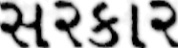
સરકાર
